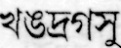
খঙদ্রগসু
